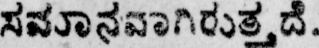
ಸಮಾನವಾಗಿರುತ್ತದೆ.
